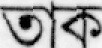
তাক
